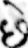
છે
